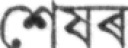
শেষৰ
